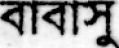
বাবাসু
